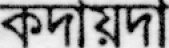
কদায়দা
